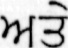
ਅਤੇ
